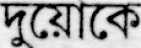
দুয়োকে
